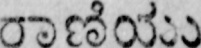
ರಾಣಿಯು
